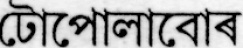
টোপোলাবোৰ
